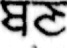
ਬਣ
